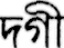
দগী
